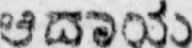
ಆದಾಯ
